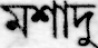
মশাদু
